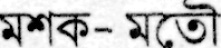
মশক-মতৌ
